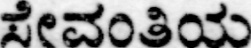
ಸೇವಂತಿಯ
